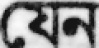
যেন
